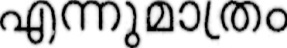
എന്നുമാത്രം
